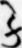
કે
